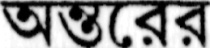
অন্তরের
